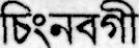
চিংনবগী
